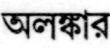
অলঙ্কার
